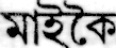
মাইকৈ
